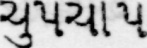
ચુપચાપ
